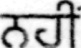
ਨਹੀਂ
